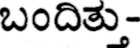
ಬಂದಿತ್ತು-
